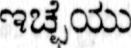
ಇಚ್ಛೆಯು
